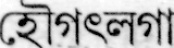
হৌগৎলগা
